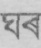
ঘৰ
